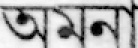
অমনা
